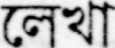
লেখা
